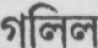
গলিল
